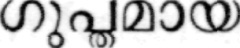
ഗുപ്തമായ
